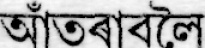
আঁতৰাবলৈ
